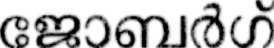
ജോബര്‍ഗ്
